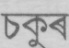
চকুৰ
